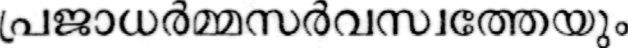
പ്രജാധര്‍മ്മസര്‍വസ്വത്തേയും
